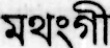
মথংগী
